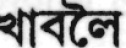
খাবলৈ
